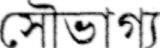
সৌভাগ্য
